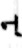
ન
